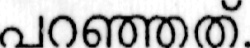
പറഞ്ഞത്.
